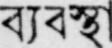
ব্যবস্থা
